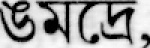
ঙমদ্রে,
